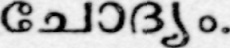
ചോദ്യം.
